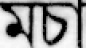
মচা
